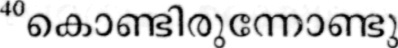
40കൊണ്ടിരുന്നോണ്ടു
